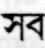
সব
